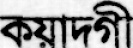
কয়াদগী
